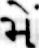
મેં
